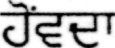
ਹੋਂਵਦਾ
